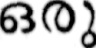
ഒരു
